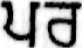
ਪਰ
